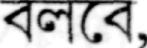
বলবে,
